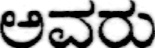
ಅವರು
